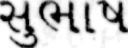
સુભાષ
